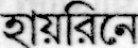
হায়রিনে
